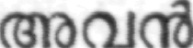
അവന്‍
